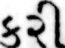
કરી
